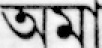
অমা
